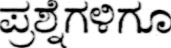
ಪ್ರಶ್ನೆಗಳಿಗೂ
